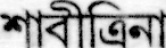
শাবীত্রিনা
